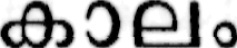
കാലം
